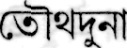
তৌথদুনা
